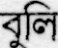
বুলি
